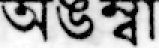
অঙম্বা
